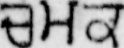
ਚਮਕ
